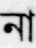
না
